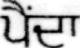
ਪੈਂਦਾ
